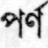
পর্ণ
